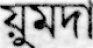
য়ুমদা
